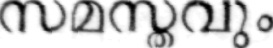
സമസ്തവും
